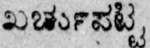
ಖರ್ಚುಪಟ್ಟಿ
